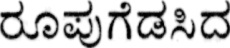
ರೂಪುಗೆಡಸಿದ
